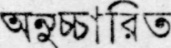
অনুচ্চারিত
